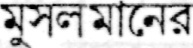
মুসলমানের
